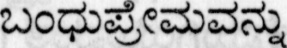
ಬಂಧುಪ್ರೇಮವನ್ನು
